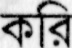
করি
